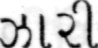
ઝારી
